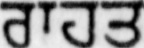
ਰਾਹਤ
